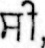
ਸੀ,
